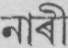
নাৰী
